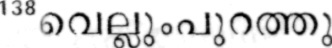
138വെല്ലുംപുറത്തു
